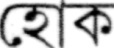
হোক
